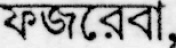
ফজরেবা,
